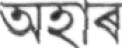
অহাৰ
